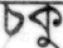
চকু
